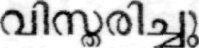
വിസ്തരിച്ചു
